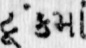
ટૂંકમાં
